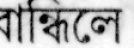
বান্ধিলে
